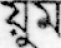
য়ুম
